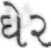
ઘેર
